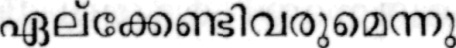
ഏല്ക്കേണ്ടിവരുമെന്നു
